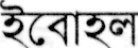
ইবোহল
